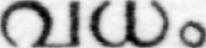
വധം
